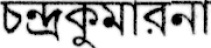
চন্দ্রকুমারনা
